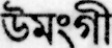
উমংগী
